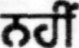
ਨਹੀਂ
